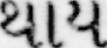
થાય
